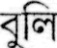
বুলি
